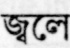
জ্বলে
